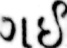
ગઈ
